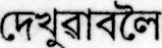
দেখুৱাবলৈ
